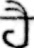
ਹੈ
